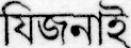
যিজনাই
